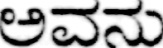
ಅವನು
